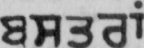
ਬਸਤਰਾਂ
